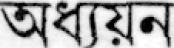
অধ্যয়ন
